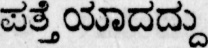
ಪತ್ತೆಯಾದದ್ದು
